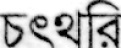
চৎথরি
